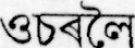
ওচৰলৈ
